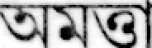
অমত্তা
